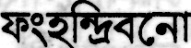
ফংহন্দ্রিবনো
